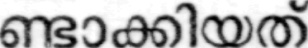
ണ്ടാക്കിയത്
